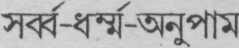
সৰ্ব্ব-ধৰ্ম্ম-অনুপাম
